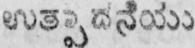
ಉತ್ಪಾದನೆಯು
